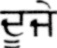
ਦੂਜੇ
